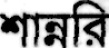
শান্নরি
